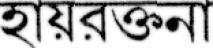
হায়রক্তনা
